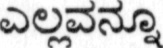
ಎಲ್ಲವನ್ನೂ
